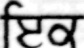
ਇਕ
